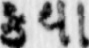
ક્યા
